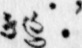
કહું.'
